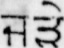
ਜੁੜੇ
